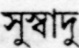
সুস্বাদু
